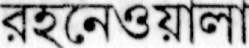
রহনেওয়ালা
